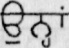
ਉਨ੍ਹਾਂ
